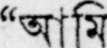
‘‘আমি
